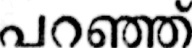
പറഞ്ഞ്
